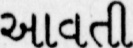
આવતી
